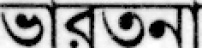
ভারতনা
